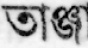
য়ূমদা
